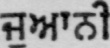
ਜੁਆਨੀ
